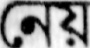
নেয়
